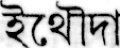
ইথৌদা
